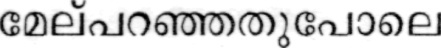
മേല്പറഞ്ഞതുപോലെ
